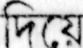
দিয়ে
